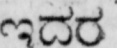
ಇದರ
